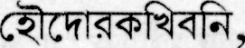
হৌদোরকখিবনি,
